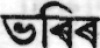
ভৰিৰ
